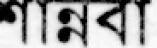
শান্নবা
